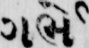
ગર્ભે
